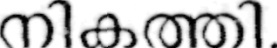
നികത്തി.
